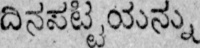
ದಿನಪಟ್ಟಿಯನ್ನು
